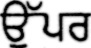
ਉੱਪਰ
